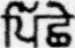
ਪਿੱਛੇ
